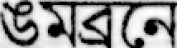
ঙমব্রনে
